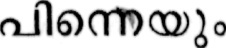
പിന്നെയും
